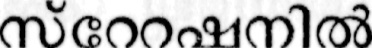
സ്റ്റേഷനില്‍
